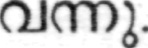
വന്നു.
